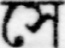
সে
